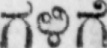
ಗಳಿಗೆ
